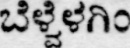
ಬೆಳ್ವೆಳಗಿಂ
